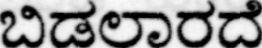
ಬಿಡಲಾರದೆ
